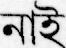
নাই
